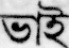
ভাই
